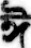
ঈ
